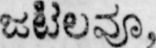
ಜಟಿಲವೂ,
